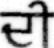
ਦੀ
